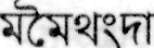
মমৈথংদা
